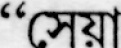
"সেয়া
